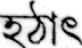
হঠাৎ
